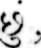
છું,
